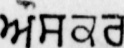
ਔਸਕਰ
